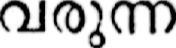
വരുന്ന
